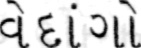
વેદાંગો
